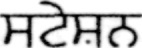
ਸਟੇਸ਼ਨ
